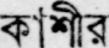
কাশীর
